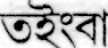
তইংবা
